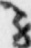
કે
